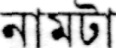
নামটা
